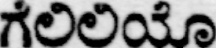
ಗೆಲಿಲಿಯೊ
